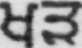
ਖੜ
